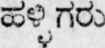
ಹಳ್ಳಿಗರು
